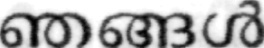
ഞങ്ങള്‍
